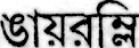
ঙায়রম্লি
